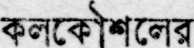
কলকৌশলের
